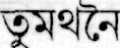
তুমথনৈ
